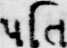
પતિ
